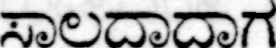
ಸಾಲದಾದಾಗ
